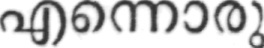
എന്നൊരു
